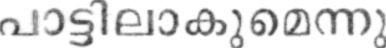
പാട്ടിലാകുമെന്നു
